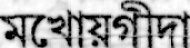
মখোয়গীদা
